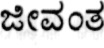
ಜೀವಂತ
